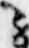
કે
